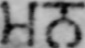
ਮਨ
